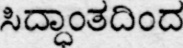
ಸಿದ್ಧಾಂತದಿಂದ
